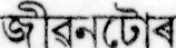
জীৱনটোৰ
